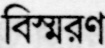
বিস্মরণ
